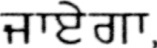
ਜਾਏਗਾ,
